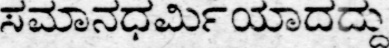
ಸಮಾನಧರ್ಮಿಯಾದದ್ದು
